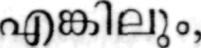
എങ്കിലും,
